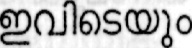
ഇവിടെയും
